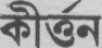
কীৰ্ত্তন
